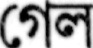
গেল
